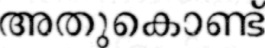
അതുകൊണ്ട്
